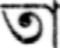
তা
